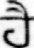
ਹੈ
